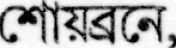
শোয়ব্রনে,
